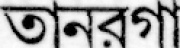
তানরগা
